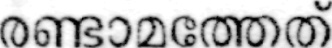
രണ്ടാമത്തേത്
